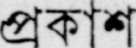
প্রকাশ
